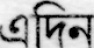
এদিন
